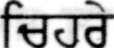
ਚਿਹਰੇ
